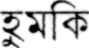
হুমকি
